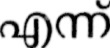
എന്ന്
